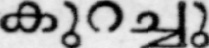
കുറച്ചു
